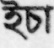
ইচা
